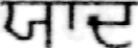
ਯਾਦ
